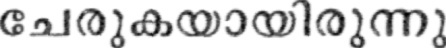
ചേരുകയായിരുന്നു
